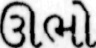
ઊભો
